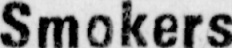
Smokers
